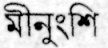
মীনুংশি
